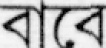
বাবে
